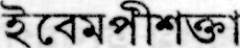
ইবেমপীশক্তা
